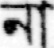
না
